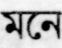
মনে
